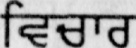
ਵਿਚਾਰ
